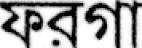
ফরগা
